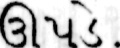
ઊપડે.
